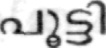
പൂട്ടി
